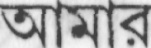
আমার
